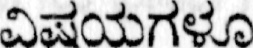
ವಿಷಯಗಳೂ
